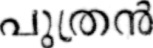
പുത്രന്‍
